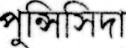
পুন্সিসিদা
